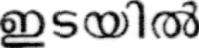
ഇടയില്‍
